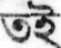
তই
